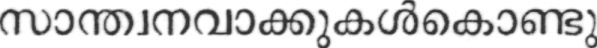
സാന്ത്വനവാക്കുകള്‍കൊണ്ടു
